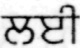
ਲਈ
